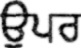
ਉਪਰ
